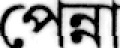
পেন্না
